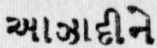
આઝાદીને
